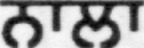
ਨਾਲਾ
